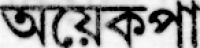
অয়েকপা
